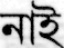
নাই
